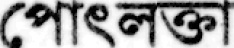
পোৎলক্তা
